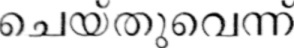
ചെയ്തുവെന്ന്
